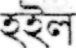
হইল
